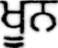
ਖੂਨ
